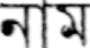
নাম
